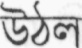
উঠল
